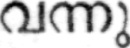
വന്നു
